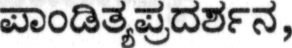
ಪಾಂಡಿತ್ಯಪ್ರದರ್ಶನ,
